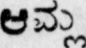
ಆಮ್ಲ
